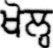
ਖੋਲ੍ਹ
